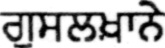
ਗੁਸਲਖ਼ਾਨੇ
